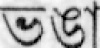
ভঙা
